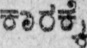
ಕಾರಕ್ಕೆ
